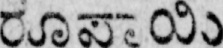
ರೂಪಾಯಿ
